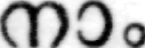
നാം
